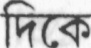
দিকে
